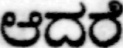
ಆದರೆ
